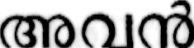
അവന്‍
